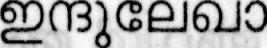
ഇന്ദുലേഖാ
